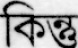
কিন্তু
